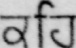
ਕਹਿ
